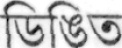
ডিঙিত
